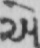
એ
